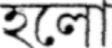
হলো
